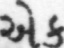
એક
